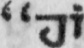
''ਹਾਂ
